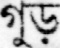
গুড়
